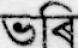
ভৰি
